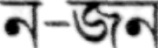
ন-জন
